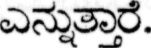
ಎನ್ನುತ್ತಾರೆ.
